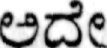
ಅದೇ
